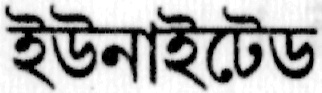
ইউনাইটেড
